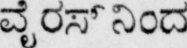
ವೈರಸ್‌ನಿಂದ
